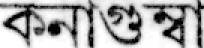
কনাগুম্বা
